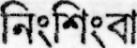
নিংশিংবা
